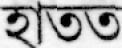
হাতত
